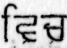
ਵਿਚ
